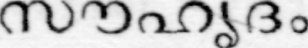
സൌഹൃദം
